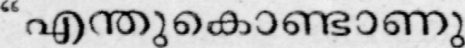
"എന്തുകൊണ്ടാണു
